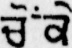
ਚੋਂਕੇ
